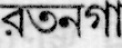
রতনগা
